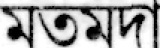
মতমদা
